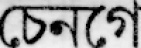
চেনগে
